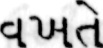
વખતે
